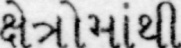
ક્ષેત્રોમાંથી
